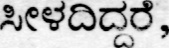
ಸೀಳದಿದ್ದರೆ,
